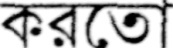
করতো
